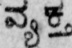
ವ್ಯಕ್ತ
